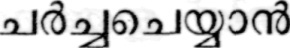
ചര്‍ച്ചചെയ്യാന്‍
